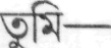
তুমি-
